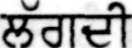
ਲੱਗਦੀ
